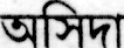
অসিদা
